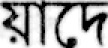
য়াদে
